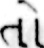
તો
